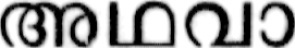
അഥവാ
